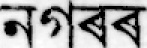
নগৰৰ
